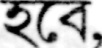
হবে,
